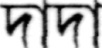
দাদা
